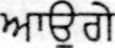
ਆਉਗੇ
